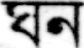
ঘন
